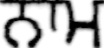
ਨਾਮ
